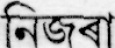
নিজৰা
